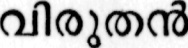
വിരുതന്‍
